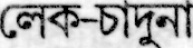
লেক-চাদুনা
